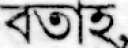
বতাহ,
